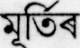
মূর্তিৰ
